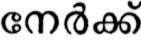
നേര്‍ക്ക്
